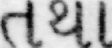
તથા
